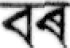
বৰ
